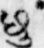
છું
